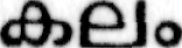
കലം
